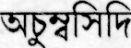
অচুম্বসিদি
